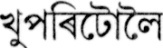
খুপৰিটোলৈ
